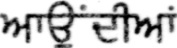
ਆਉਂਦੀਆਂ
